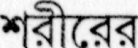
শরীরের
